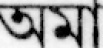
অমা
